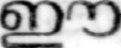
ഈ
